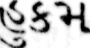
હુકમ
